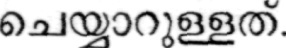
ചെയ്യാറുള്ളത്.
